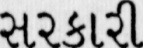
સરકારી
